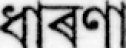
ধাৰণা
